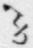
કે
